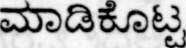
ಮಾಡಿಕೊಟ್ಟ
